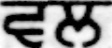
ਵਲ
